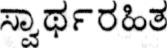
ಸ್ವಾರ್ಥರಹಿತ
